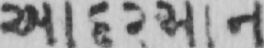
આદરમાન
